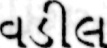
વડીલ
